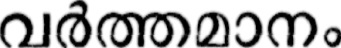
വര്‍ത്തമാനം
